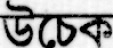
উচেক
